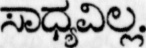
ಸಾಧ್ಯವಿಲ್ಲ.
